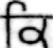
ਕਿ
